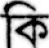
কি
